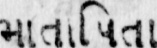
માતાપિતા
